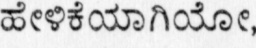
ಹೇಳಿಕೆಯಾಗಿಯೋ,
